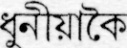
ধুনীয়াকৈ
